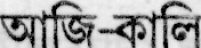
আজি-কালি
